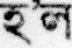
হ'ল
